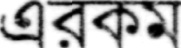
এরকম
